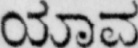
ಯಾವ
